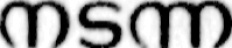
നടന്ന
